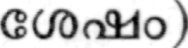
ശേഷം)
